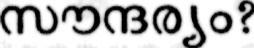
സൌന്ദര്യം?
